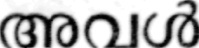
അവള്‍
